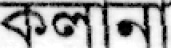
কলানা
